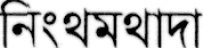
নিংথমথাদা
